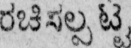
ರಚಿಸಲ್ಪಟ್ಟ
